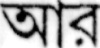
আর
